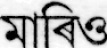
মাৰিও
